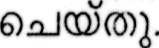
ചെയ്തു.
